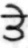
ਤੇ
